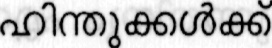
ഹിന്തുക്കള്‍ക്ക്
